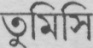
তুমিসি
